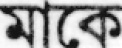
মাকে
